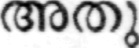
അതു
